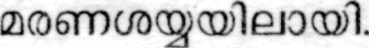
മരണശയ്യയിലായി.
